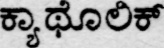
ಕ್ಯಾಥೊಲಿಕ್
